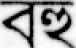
বহু
